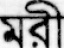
মরী
